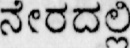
ನೇರದಲ್ಲಿ
